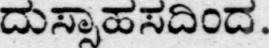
ದುಸ್ಸಾಹಸದಿಂದ.
